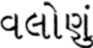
વલોણું
